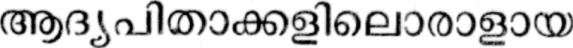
ആദ്യപിതാക്കളിലൊരാളായ
